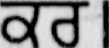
ਕਰ।
